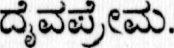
ದೈವಪ್ರೇಮ.
